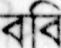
ববি
